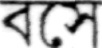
বসে
